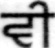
ਵੀ
